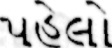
પહેલો
